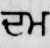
ਦਮ
